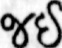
જઈ
